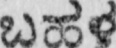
ಬಹಳ
